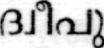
ദ്വീപു
